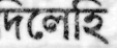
দিলেহি
